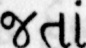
જતાં
